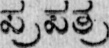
ಪ್ರಪತ್ರ
